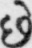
છે
